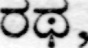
ರಥ,
